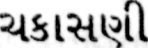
ચકાસણી
